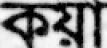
কয়া
